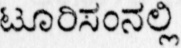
ಟೂರಿಸಂನಲ್ಲಿ
